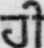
ਹੀ
